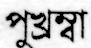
পুখ্রম্বা
